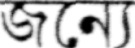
জন্যে
